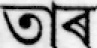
তাৰ
